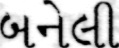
બનેલી
